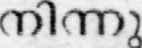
നിന്നു
